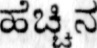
ಹೆಚ್ಚಿನ
